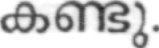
കണ്ടു.
